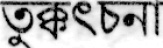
তুক্কৎচনা
